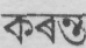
কৰন্ত
